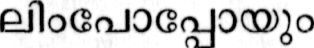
ലിംപോപ്പോയും
